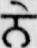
ਨੇ
